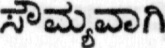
ಸೌಮ್ಯವಾಗಿ
